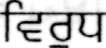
ਵਿਰੁਧ
